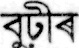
বুঢ়ীৰ
